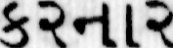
કરનાર
